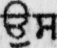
ਉਸ
